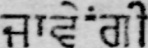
ਜਾਵੇਂਗੀ
